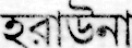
হরাউনা
